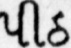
પીઠ
